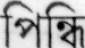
পিন্ধি
